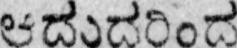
ಆದುದರಿಂದ
